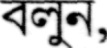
বলুন,
